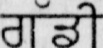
ਗੱਡੀ
